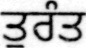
ਤੁਰੰਤ
